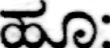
ಹೂ:
